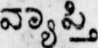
ವ್ಯಾಪ್ತಿ
